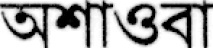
অশাওবা
